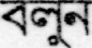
বলুন
